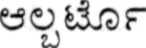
ಆಲ್ಬರ್ಟೊ
